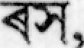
ৰস,
